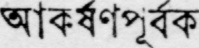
আকর্ষণপূর্বক
